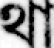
থা
